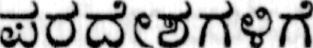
ಪರದೇಶಗಳಿಗೆ
